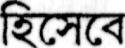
হিসেবে
